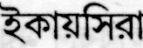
ইকায়সিরা
